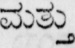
ಮತ್ತು
